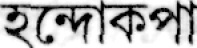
হন্দোকপা
